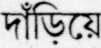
দাঁড়িয়ে
